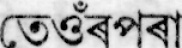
তেওঁৰপৰা
